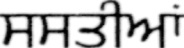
ਸਸਤੀਆਂ
